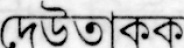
দেউতাকক
